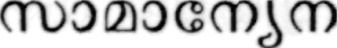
സാമാന്യേന
